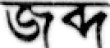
জব্দ
